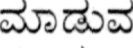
ಮಾಡುವ
